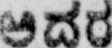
ಅದರ
